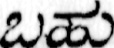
ಬಹು
